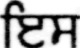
ਇਸ
